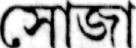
সোজা
